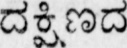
ದಕ್ಷಿಣದ
